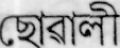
ছোৱালী
